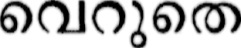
വെറുതെ
